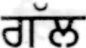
ਗੱਲ
